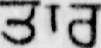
ਤਾਰ
